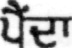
ਪੈਂਦਾ
